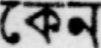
কেন
